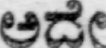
ಅದೇ
